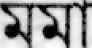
মমা
